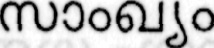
സാംഖ്യം
